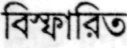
বিস্ফারিত
